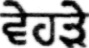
ਵੇਹੜੇ
